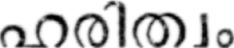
ഹരിത്വം
